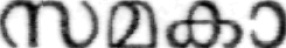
സമകാ
